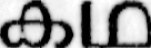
കഥ
